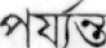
পয্যর্ন্ত
